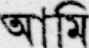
আমি
